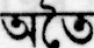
অতৈ
